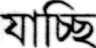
যাচ্ছি
